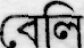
বেলি
